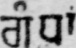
ਗੰਧਾਂ
